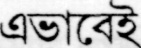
এভাবেই
